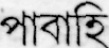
পাবাহি
